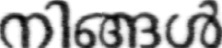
നിങ്ങള്‍
